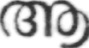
ആ
